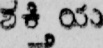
ಶಕ್ತಿಯ
